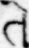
તે
